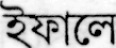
ইফালে
